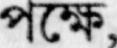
পক্ষে,
